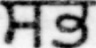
ਸਭ
